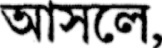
আসলে,
